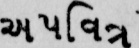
અપવિત્ર
